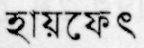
হায়ফেৎ
